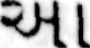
આ
